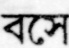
বসে
